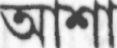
আশা
